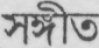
সঙ্গীত
